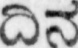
ದಿನ
